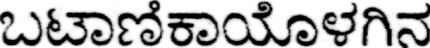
ಬಟಾಣಿಕಾಯೊಳಗಿನ
